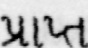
પ્રાપ્ત
